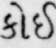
કોઈ
